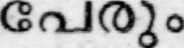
പേരും
